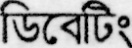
ডিবেটিং
